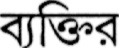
ব্যক্তির
